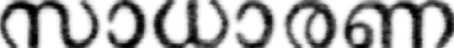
സാധാരണ
